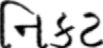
નિકટ
